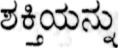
ಶಕ್ತಿಯನ್ನು
